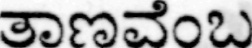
ತಾಣವೆಂಬ
